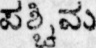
ಪಶ್ಚಿಮ
